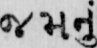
જમનું
